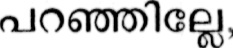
പറഞ്ഞില്ലേ,
